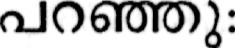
പറഞ്ഞു:
